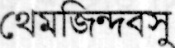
থেমজিন্দবসু
